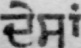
ਦੇਸਾਂ
